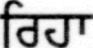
ਰਿਹਾ
